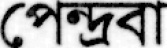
পেন্দ্রবা
